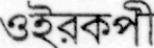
ওইরকপী
